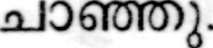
ചാഞ്ഞു.
